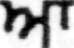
ਆ
